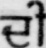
ਦੀ
